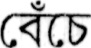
বেঁচে
